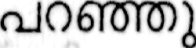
പറഞ്ഞു
